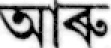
আৰু
